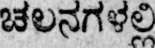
ಚಲನಗಳಲ್ಲಿ
